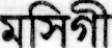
মসিগী
